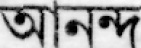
আনন্দ
